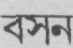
বসন
